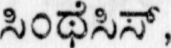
ಸಿಂಥೆಸಿಸ್,
